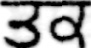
ਤਕ
